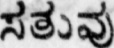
ಸತುವು
